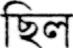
ছিল
